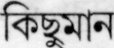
কিছুমান
